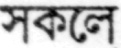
সকলে
